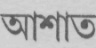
আশাত
